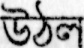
উঠল
